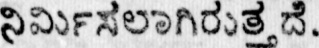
ನಿರ್ಮಿಸಲಾಗಿರುತ್ತದೆ.
